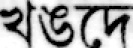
খঙদে
